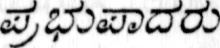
ಪ್ರಭುಪಾದರು
